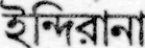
ইন্দিরানা
